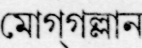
মোগ্গল্লান
